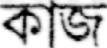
কাজ
